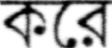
করে
